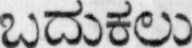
ಬದುಕಲು
